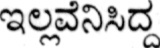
ಇಲ್ಲವೆನಿಸಿದ್ದ
